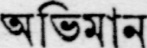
অভিমান
